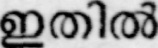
ഇതില്‍
